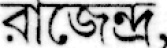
রাজেন্দ্র,
